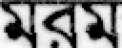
মরম
